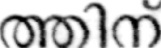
ത്തിന്
